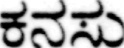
ಕನಸು
